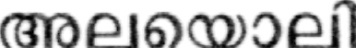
അലയൊലി
